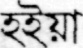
হইয়া
